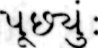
પૂછયુંઃ
